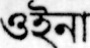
ওইনা
